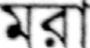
মরা
